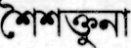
শৈশক্তুনা
